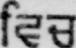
ਵਿਚ
